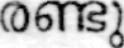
രണ്ടു
